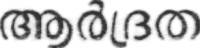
ആര്‍ദ്രത
